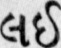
લઈ
